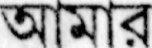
আমার
